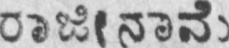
ರಾಜೀನಾಮೆ
